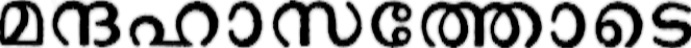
മന്ദഹാസത്തോടെ
